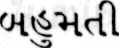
બહુમતી
